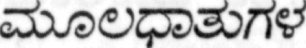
ಮೂಲಧಾತುಗಳ
